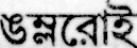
ঙম্লোরোই
